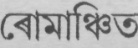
ৰোমাঞ্চিত
